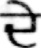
ਦੇ
